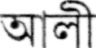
আলী
